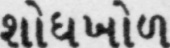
શોધખોળ
